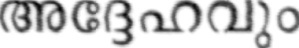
അദ്ദേഹവും
